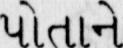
પોતાને
